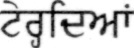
ਟੇਰ੍ਹਦਿਆਂ
